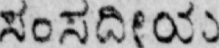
ಸಂಸದೀಯ
